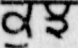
ਕੁਝ
